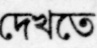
দেখতে
